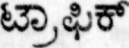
ಟ್ರಾಫಿಕ್
